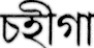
চহীগা
